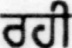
ਰਹੀ
